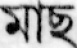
মাছ
